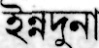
ইন্নদুনা
